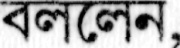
বললেন,
